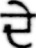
ਦੇ
